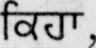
ਕਿਹਾ,
